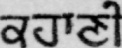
ਕਹਾਣੀ
